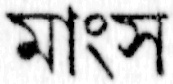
মাংস
